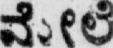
ಮೇಲೆ
